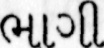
ભાગી
